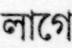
লাগে
